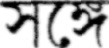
সঙ্গে
